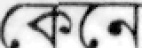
কেনে
